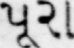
પૂરા
